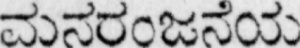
ಮನರಂಜನೆಯ
